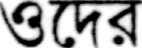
ওদের
